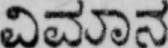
ವಿಮಾನ
